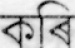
কৰি
